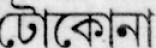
টোকোনা
